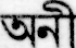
অনী
